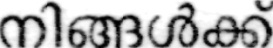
നിങ്ങള്‍ക്ക്
